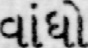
વાંધો
